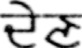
ਦੇਣ
